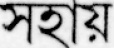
সহায়
